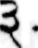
રૂ.
